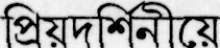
প্রিয়দৰ্শিনীয়ে
